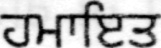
ਹਮਾਇਤ
